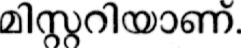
മിസ്റ്ററിയാണ്.
